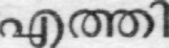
എത്തി
